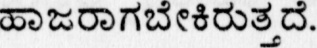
ಹಾಜರಾಗಬೇಕಿರುತ್ತದೆ.
